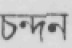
চন্দন
